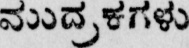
ಮುದ್ರಕಗಳು
